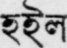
হইল
